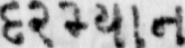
દરમ્યાન
